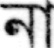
না
